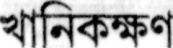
খানিকক্ষণ
